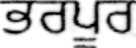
ਭਰਪੂਰ
